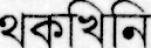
থকখিনি
